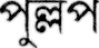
পুল্লপ
